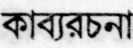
কাব্যরচনা
